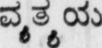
ವ್ಯತ್ಯಯ
